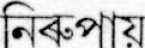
নিৰুপায়
